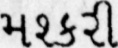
મશ્કરી
